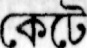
কেটে
